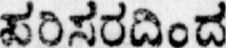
ಪರಿಸರದಿಂದ
